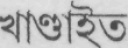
খাণ্ডাইত
